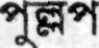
পুল্লপ
